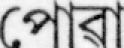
পোৱা
